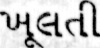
ખૂલતી
